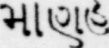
માણહ
